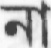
না
